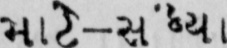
માટે-સંધ્યા
